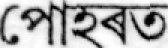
পোহৰত
